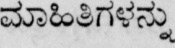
ಮಾಹಿತಿಗಳನ್ನು
